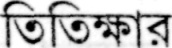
তিতিক্ষার
